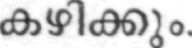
കഴിക്കും.
